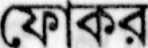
ফোকর
